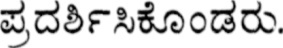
ಪ್ರದರ್ಶಿಸಿಕೊಂಡರು.
